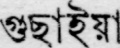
গুছাইয়া
